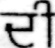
ਦੀ
